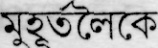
মুহূর্তলৈকে
